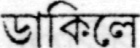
ডাকিলে
